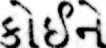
કોઈને
